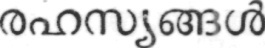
രഹസ്യങ്ങള്‍
